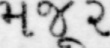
મજૂર
